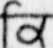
ਕਿ
